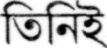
তিনিই
